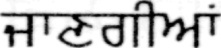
ਜਾਣਗੀਆਂ
